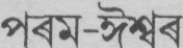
পৰম-ঈশ্বৰ
